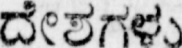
ದೇಶಗಳು
